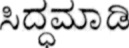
ಸಿದ್ಧಮಾಡಿ
